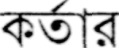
কর্তার
